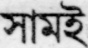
সামই
